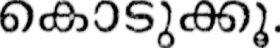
കൊടുക്കൂ.
